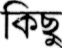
কিছু
